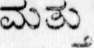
ಮತ್ತು
